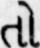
તો
